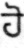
ਹੋ
